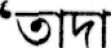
‘তাদা
